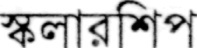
স্কলারশিপ
